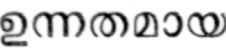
ഉന്നതമായ
